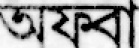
অফবা
